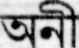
অনী
